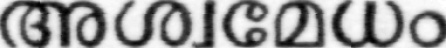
അശ്വമേധം
